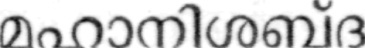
മഹാനിശബ്ദ
